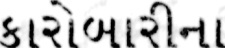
કારોબારીના
